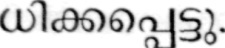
ധിക്കപ്പെട്ടു.
